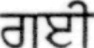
ਗਈ
